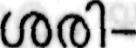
ശരി-
